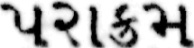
પરાક્રમ
